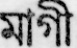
মাগী
